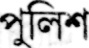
পুলিশ
